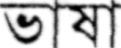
ভাষা
